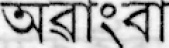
অৱাংবা
